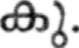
കു.
